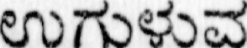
ಉಗುಳುವ
